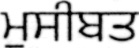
ਮੁਸੀਬਤ
